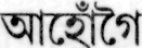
আহোঁগৈ
